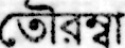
তৌরম্বা
